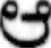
ಆ
